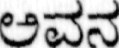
ಅವನ
